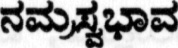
ನಮ್ರಸ್ವಭಾವ
